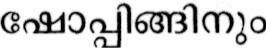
ഷോപ്പിങ്ങിനും
